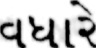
વધારે
